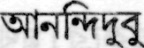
আনন্দিদুবু
